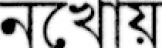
নখোয়
